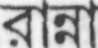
রান্না
